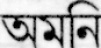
অমনি
